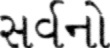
સર્વનો
